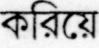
করিয়ে
